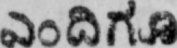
ಎಂದಿಗೂ
